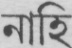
নাহি
